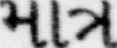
માત્ર
